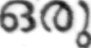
ഒരു
